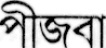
পীজবা
